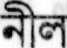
নীল
